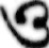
ও
